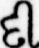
દી
